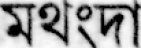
মথংদা
